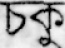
চকু
